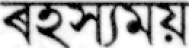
ৰহস্যময়
